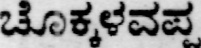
ಚೊಕ್ಕಳವಪ್ಪ
